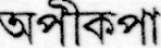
অপীকপা
